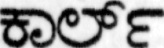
ಕಾರ್ಲ್
